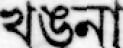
খঙনা
